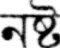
নষ্ট
